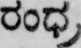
ರಂಧ್ರ
